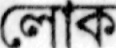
লোক
